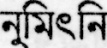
নুমিৎনি
